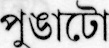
পুঙাটো
